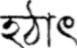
হঠাত্
